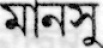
মানসু
